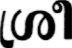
ശ്രീ
